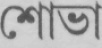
শোভা
